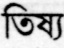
তিষ্য
